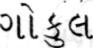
ગોકુલ
